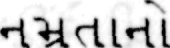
નમ્રતાનો
